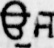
ਉਸ
